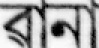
ৱানা
